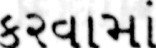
કરવામાં
